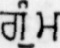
ਗੁੰਮ
